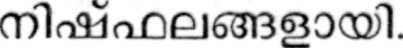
നിഷ്ഫലങ്ങളായി.
